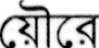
য়ৌরে
